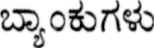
ಬ್ಯಾಂಕುಗಳು
